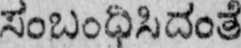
ಸಂಬಂಧಿಸಿದಂತೆ
